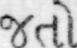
જતો
